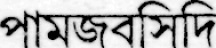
পামজবসিদি
